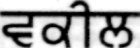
ਵਕੀਲ
